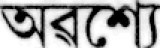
অৱশ্যে
